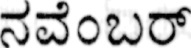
ನವೆಂಬರ್
